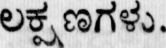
ಲಕ್ಷಣಗಳು.
